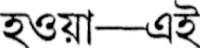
হওয়া-এই
